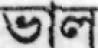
ভাল
